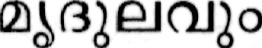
മൃദുലവും
